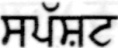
ਸਪੱਸ਼ਟ
